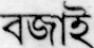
বজাই
